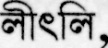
লীৎলি,
